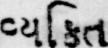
વ્યક્તિ
